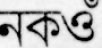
নকওঁ
